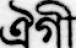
ঐগী
